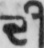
ਦੀ
